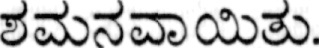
ಶಮನವಾಯಿತು.
